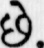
છે.
